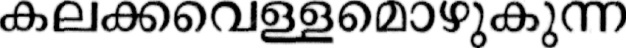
കലക്കവെള്ളമൊഴുകുന്ന
